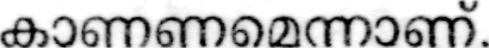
കാണണമെന്നാണ്.
